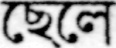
ছেলে
